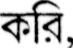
করি,
